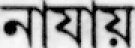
নাযায়
